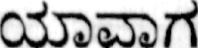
ಯಾವಾಗ
